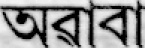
অৱাবা
